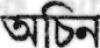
অচিন
